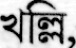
খল্লি,
